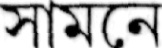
সামনে
